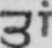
ਤਾਂ
